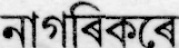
নাগৰিকৰে
